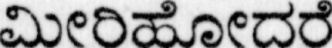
ಮೀರಿಹೋದರೆ
